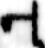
ન
